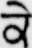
ਕੇ
